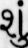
શું
